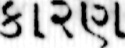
કારણ
